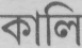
কালি
